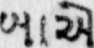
બાએ
